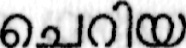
ചെറിയ
